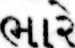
ભારે
